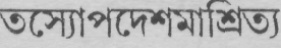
তস্যোপদেশমাশ্ৰিত্য
